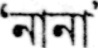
‘নানা’
